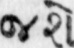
જશે
